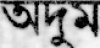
অদুম
